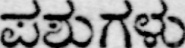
ಪಶುಗಳು
